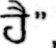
ਹੈ'',
